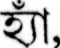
হ্যাঁ,
